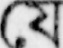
যে
